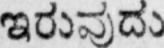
ಇರುವುದು
